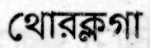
থোরক্লগা
